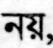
নয়,
